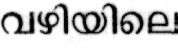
വഴിയിലെ
